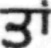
ਤਾਂ
